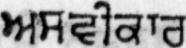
ਅਸਵੀਕਾਰ
